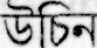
উচিন
